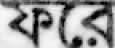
ফরে
